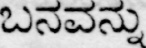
ಬನವನ್ನು
